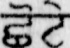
ਛੋਟੇ
